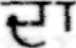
ਦਾ
